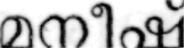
മനീഷ്
